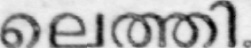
ലെത്തി.
